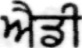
ਐਡੀ
